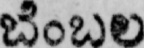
ಬೆಂಬಲ
